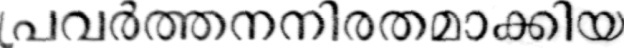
പ്രവര്‍ത്തനനിരതമാക്കിയ
